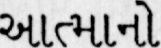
આત્માનો
